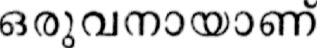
ഒരുവനായാണ്
